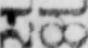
ಸಹ
